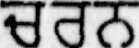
ਚਰਨ
